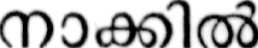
നാക്കില്‍
